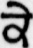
ਕੇ
